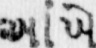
આંખે
